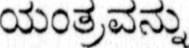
ಯಂತ್ರವನ್ನು
